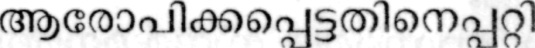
ആരോപിക്കപ്പെട്ടതിനെപ്പറ്റി
